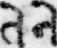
તેને
